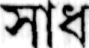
সাধ
